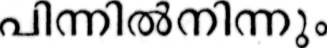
പിന്നില്‍നിന്നും
